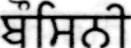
ਬੌਸਿਨੀ
